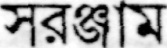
সরঞ্জাম
